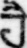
ਹੈ
